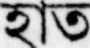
হাত
